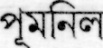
পূমনিল
